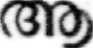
ആ
